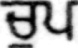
ਚੁਪ
